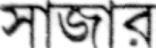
সাজার
